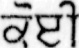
ਕੋਈ
